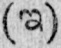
(ಇ)
